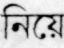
নিয়ে
